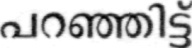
പറഞ്ഞിട്ട്
